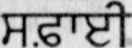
ਸਫ਼ਾਈ
